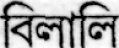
বিলালি
